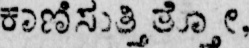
ಕಾಣಿಸುತ್ತಿತ್ತೋ,
